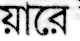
য়ারে
